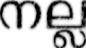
നല്ല
